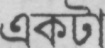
একটা
